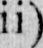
ii)
